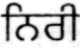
ਨਿਰੀ
